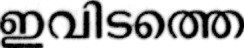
ഇവിടത്തെ
